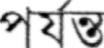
পর্যন্ত
